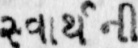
સ્વાર્થની
